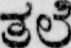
ತಲೆ
